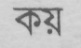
কয়
